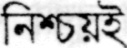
নিশ্চয়ই
